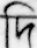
দি
